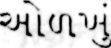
ઓળખું
